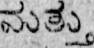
ಮತ್ತು
